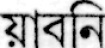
য়াবনি
